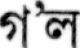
গ'ল
